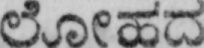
ಲೋಹದ
